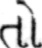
તો
